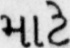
માટે
